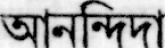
আনন্দিদা
